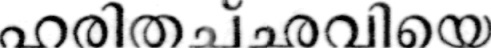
ഹരിതച്ഛവിയെ
